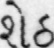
શેઠ
